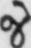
જે
